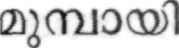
മുമ്പായി
